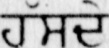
ਹੱਸਦੇ
